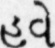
હવે
